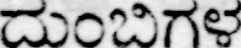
ದುಂಬಿಗಳ
